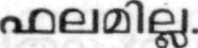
ഫലമില്ല.
